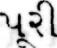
પૂરી
